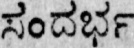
ಸಂದರ್ಭ
